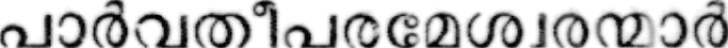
പാര്‍വതീപരമേശ്വരന്മാര്‍
